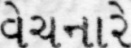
વેચનારે
